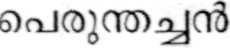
പെരുന്തച്ചന്‍
